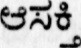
ಆಸಕ್ತಿ
